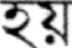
হয়
